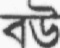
বউ
